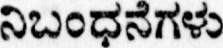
ನಿಬಂಧನೆಗಳು
